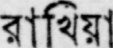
রাখিয়া
